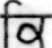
ਕਿ
